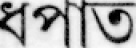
ধপাত
